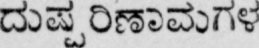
ದುಷ್ಪರಿಣಾಮಗಳ
